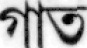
গাত
